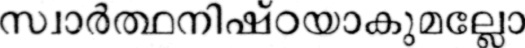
സ്വാര്‍ത്ഥനിഷ്ഠയാകുമല്ലോ
